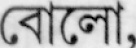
বোলো,
